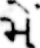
મેં
